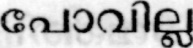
പോവില്ല
